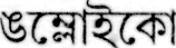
ঙম্লোইকো
